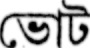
ভোট
